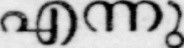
എന്നു
